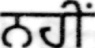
ਨਹੀਂ
